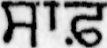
ਸਾਫ਼
